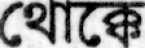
থোক্কে
